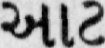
આટ
